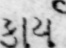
કાર્ય
